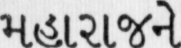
મહારાજને
